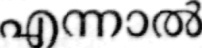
എന്നാല്‍
